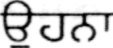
ਉਹਨਾ
